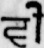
ਵੀ
